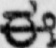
ಈ
